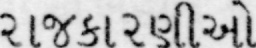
રાજકરણીઓ
